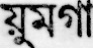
য়ুমগা
